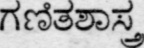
ಗಣಿತಶಾಸ್ತ್ರ
